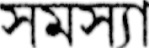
সমস্যা
